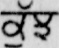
ਕੁੱਝ
